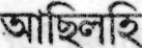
আছিলহি
